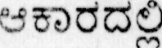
ಆಕಾರದಲ್ಲಿ
